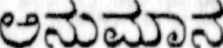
ಅನುಮಾನ
